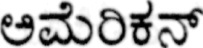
ಅಮೆರಿಕನ್
